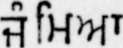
ਜੰਮਿਆ
